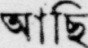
আছি
